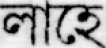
লাহে
